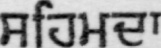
ਸਹਿਮਦਾ
